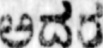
ಅದರ
